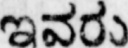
ಇವರು
